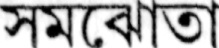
সমঝোতা
